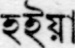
হইয়া
